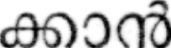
ക്കാന്‍
